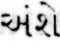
અંશે
